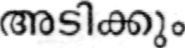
അടിക്കും
